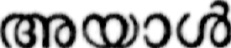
അയാള്‍
